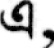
এ,
